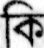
কি
